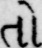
તો
